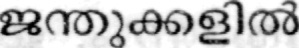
ജന്തുക്കളില്‍
